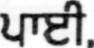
ਪਾਈ,
